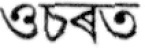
ওচৰত
